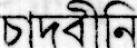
চাদবীনি
